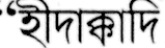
“হীদাক্কদি
